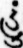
હું
